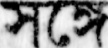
সঙ্গে
